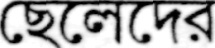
ছেলেদের
